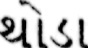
થોડા
